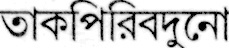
তাকপিরিবদুনো
